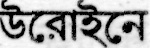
উরোইনে
